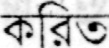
করিত
